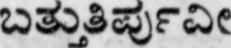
ಬತ್ತುತಿರ್ಪುವೀ
